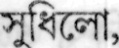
সুধিলো,
